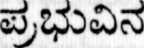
ಪ್ರಭುವಿನ
